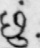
છું.
